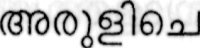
അരുളിചെ
